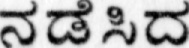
ನಡೆಸಿದ
